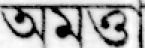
অমত্তা
